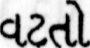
વટતો
